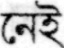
নেই
